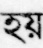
হয়
